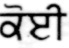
ਕੋਈ
